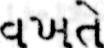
વખતે
